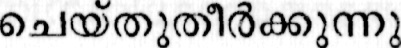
ചെയ്തുതീര്‍ക്കുന്നു
